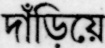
দাঁড়িয়ে
